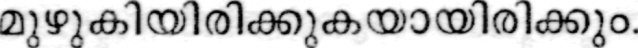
മുഴുകിയിരിക്കുകയായിരിക്കും.
